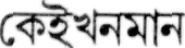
কেইখনমান
